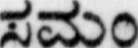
ಸಮಂ
